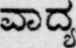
ವಾದ್ಯ
